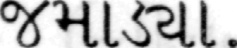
જમાડ્યા.
